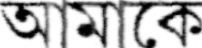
আমাকে
